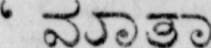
‘ಮಾತಾ
